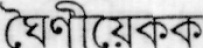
ঘৈণীয়েকক
